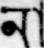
না
